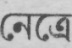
নেত্ৰে
